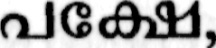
പക്ഷേ,
